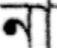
না
